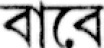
বাবে
